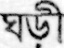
ঘড়ী
